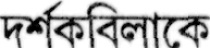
দর্শকবিলাকে
